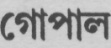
গোপাল
